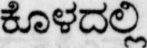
ಕೊಳದಲ್ಲಿ
